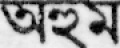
অহুম
